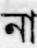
না
